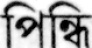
পিন্ধি
